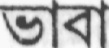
ভাবা
